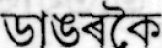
ডাঙৰকৈ
